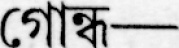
গোন্ধ-
